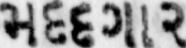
મદદગાર
